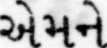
એમને
